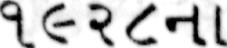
૧૯૨૮ના
